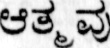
ಆತ್ಮವು
